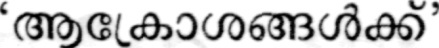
‘ആക്രോശങ്ങള്‍ക്ക്'
